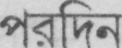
পরদিন
